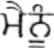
ਮੈਨੂੰ
